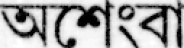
অশেংবা
